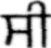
ਸੀ
